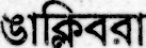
ঙাক্লিবরা
